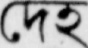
দেহ
